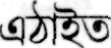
এঠাইত
